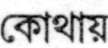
কোথায়
